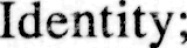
Identity;
